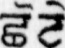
ਛੋਟੇ
